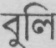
বুলি
